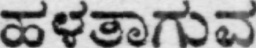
ಹಳತಾಗುವ
